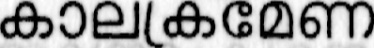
കാലക്രമേണ
